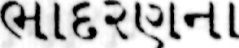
ભાદરણના
